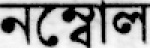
নম্বোল
